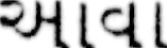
આવા
